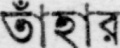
তাঁহার
